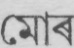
মোৰ
